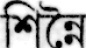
শিন্নৈ
